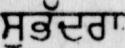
ਸੁਭੱਦਰਾ
